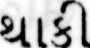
થાકી
